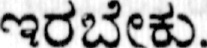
ಇರಬೇಕು.
